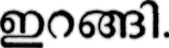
ഇറങ്ങി.
